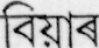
বিয়াৰ
